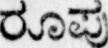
ರೂಪು
